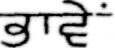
ਭਾਵੇਂ
